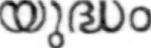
യുദ്ധം
